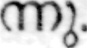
ന്നു.
